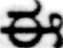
ಈ
